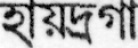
হায়দ্রগা
